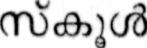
സ്കൂള്‍
